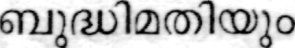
ബുദ്ധിമതിയും
